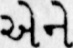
એને
